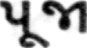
પૂજા
